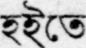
হইতে
